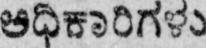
ಅಧಿಕಾರಿಗಳು
